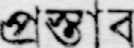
প্রস্তাব
